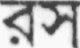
রস
